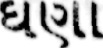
ઘણા
